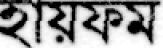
হায়ফম
